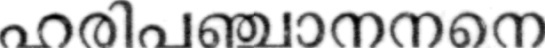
ഹരിപഞ്ചാനനനെ
